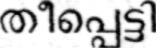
തീപ്പെട്ടി
